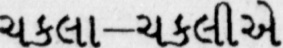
ચકલા-ચકલીએ
